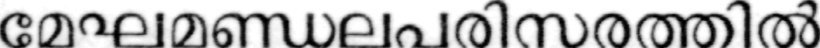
മേഘമണ്ഡലപരിസരത്തില്‍
